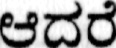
ಆದರೆ,
